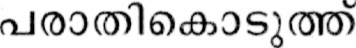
പരാതികൊടുത്ത്
